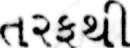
તરફથી
